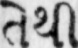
તેથી
